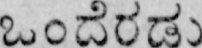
ಒಂದೆರಡು
